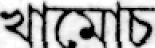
খামোচ
